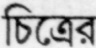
চিত্রের
